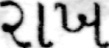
રાખ
